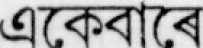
একেবাৰে
